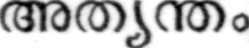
അത്യന്തം
